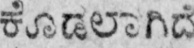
ಕೊಡಲಾಗಿದೆ
